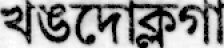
খঙদোক্লগা
